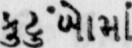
કુટુંબોમાં
